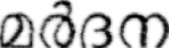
മര്‍ദന
